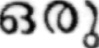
ഒരു
